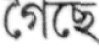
গেছে
